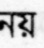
নয়
